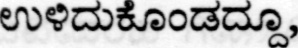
ಉಳಿದುಕೊಂಡದ್ದೂ,
